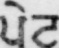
ਪੇਟ
